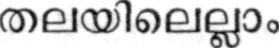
തലയിലെല്ലാം
